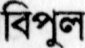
বিপুল
